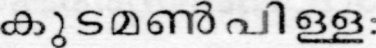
കുടമണ്‍പിള്ള:
